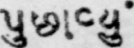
પુછાવ્યું
